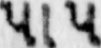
પાપ
